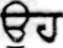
ਉਹ
